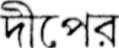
দীপের
